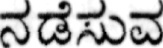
ನಡೆಸುವ
